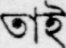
তাই
